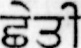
ਛੇਤੀ
